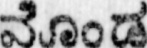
ಮೊಂಡ
